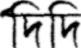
দিদি
